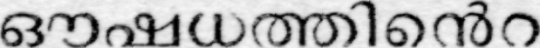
ഔഷധത്തിന്റെ
